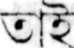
তাই
